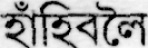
হাঁহিবলৈ
